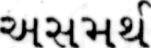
અસમર્થ
